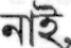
নাই,
